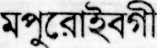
মপুরোইবগী
